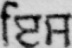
ਇਸ
